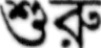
শুরু
